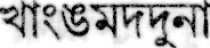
খাংঙমদদুনা
